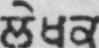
ਲੇਖਕ
